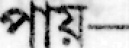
পায়-
